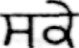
ਸਕੇ
